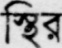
স্থির
